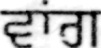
ਵਾਂਗ
